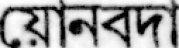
য়োনবদা
